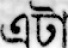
এটা
